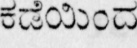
ಕಡೆಯಿಂದ
